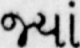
જ્યાં
